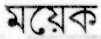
ময়েক
